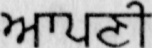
ਆਪਣੀ
